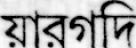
য়ারগদি
